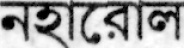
নহারোল
